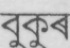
বুকুৰ
